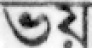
ভয়
